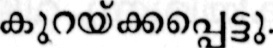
കുറയ്ക്കപ്പെട്ടു.
